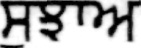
ਸੁਝਾਅ
